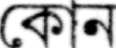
কোন
